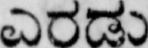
ಎರಡು
